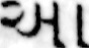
આ
